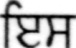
ਇਸ
